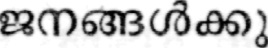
ജനങ്ങള്‍ക്കു
